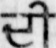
ਦੀ
